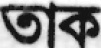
তাক
